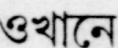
ওখানে
